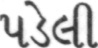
પડેલી
